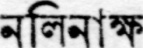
নলিনাক্ষ
